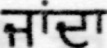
ਜਾਂਦਾ
